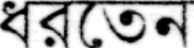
ধরতেন
